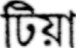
টিয়া
